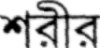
শরীর
